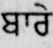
ਬਾਰੇ
